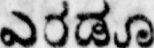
ಎರಡೂ
